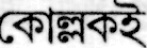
কোল্লকই
